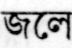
জলে
